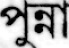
পু্ন্না
